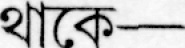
থাকে-
